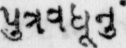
પુત્રવધૂનું
